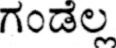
ಗಂಡೆಲ್ಲ
